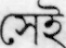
সেই
